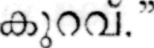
കുറവ്."
